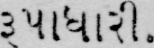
રૂપાધારી.
